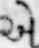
એ
